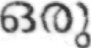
ഒരു
